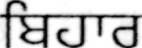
ਬਿਹਾਰ
